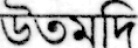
উতমদি
